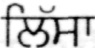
ਲਿੱਸਾ
